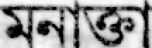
মনাক্তা
